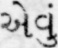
એવું
